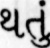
થતું
